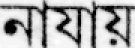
নাযায়
